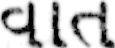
વાત
